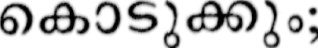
കൊടുക്കും;
